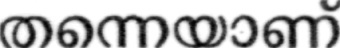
തന്നെയാണ്
